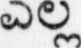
ಎಲ್ಲ
